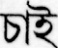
চাই
